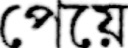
পেয়ে
